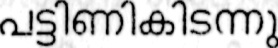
പട്ടിണികിടന്നു
